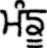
ਮੰਙੂ
